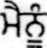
ਮੈਨੂੰ
